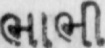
ભાભી
